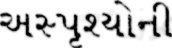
અસ્પૃશ્યોની
